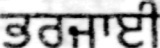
ਭਰਜਾਈ
